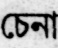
চেনা
